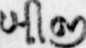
બીજી
